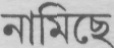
নামিছে
